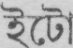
ইটো
